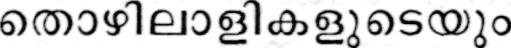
തൊഴിലാളികളുടെയും
